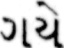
ગયે
